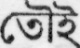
তৌই
